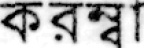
করম্বা
